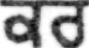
ਕਰ
